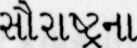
સૌરાષ્ટ્રના
